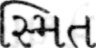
સ્મિત
